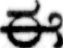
ಈ
